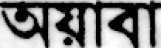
অয়াবা
